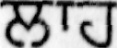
ਲਾਹ
